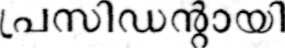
പ്രസിഡന്റായി
